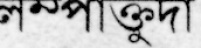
লম্পাক্তুদা
